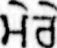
ਮੇਰੇ
